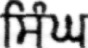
ਸਿੰਘ
